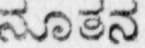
ನೂತನ
